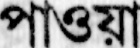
পাওয়া
